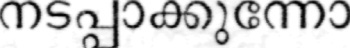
നടപ്പാക്കുന്നോ
